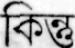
কিন্ত
